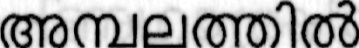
അമ്പലത്തില്‍
